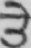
ਤੇ
